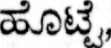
ಹೊಟ್ಟೆ,
